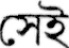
সেই
